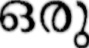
ഒരു
